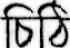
চিঠি
